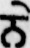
ਨੇ
